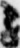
કે
